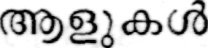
ആളുകള്‍
